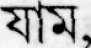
যাম,
